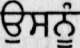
ਉਸਨੂੰ
